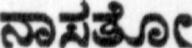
ನಾಸತೋ
